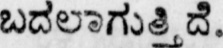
ಬದಲಾಗುತ್ತಿದೆ.
